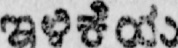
ಇಳಿಕೆಯ
